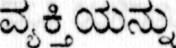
ವ್ಯಕ್ತಿಯನ್ನು
